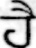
ਹੈ
